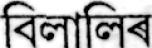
বিলালিৰ
